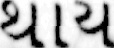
થાય
